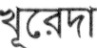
খূরেদা
